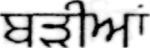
ਬੜੀਆਂ
